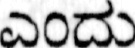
ಎಂದು
